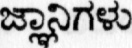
ಜ್ಞಾನಿಗಳು
